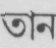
তান
